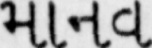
માનવ
